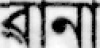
ৱানা
